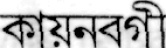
কায়নবগী
